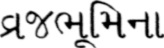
વ્રજભૂમિના
